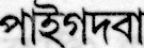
পাইগদবা
